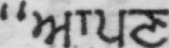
''ਆਪਣ
